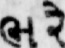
ભરે
